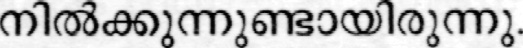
നില്‍ക്കുന്നുണ്ടായിരുന്നു.
